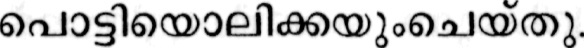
പൊട്ടിയൊലിക്കയുംചെയ്തു.
